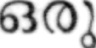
ഒരു
